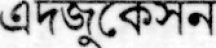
এদজুকেসন
